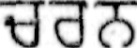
ਚਰਨ
